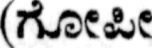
(ಗೋಪೀ
